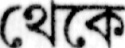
থেকে
